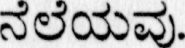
ನೆಲೆಯವು.
